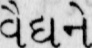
વૈધને
